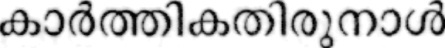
കാര്‍ത്തികതിരുന്നാള്‍
